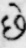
છે
